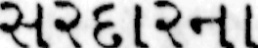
સરદારના
